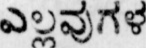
ಎಲ್ಲವುಗಳ
